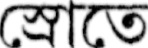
স্রোতে
